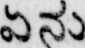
ಏನು
